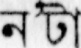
ন'টা
